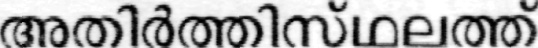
അതിര്‍ത്തിസ്ഥലത്ത്
